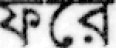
ফরে
